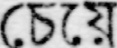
চেয়ে
